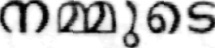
നമ്മുടെ
